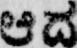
ಆದ
